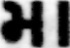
મા
